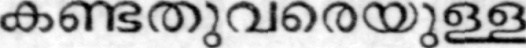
കണ്ടതുവരെയുള്ള
